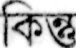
কিন্তু
